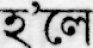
হ'লে
